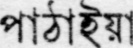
পাঠাইয়া
